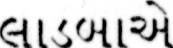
લાડબાએ
